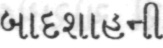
બાદશાહની
